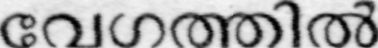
വേഗത്തില്‍
